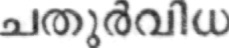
ചതുര്‍വിധ
